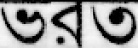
ভরত
